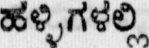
ಹಳ್ಳಿಗಳಲ್ಲಿ
